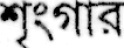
শৃংগার
